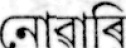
নোৱাৰি
